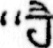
''ਹੈ
